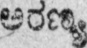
ಅರಣ್ಯ
